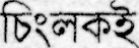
চিংলকই
